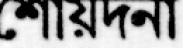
শোয়দনা
